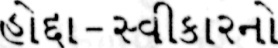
હોદ્દા-સ્વીકારનો
